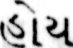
હોય
